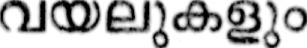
വയലുകളും
